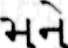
મને
